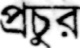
প্রচুর
